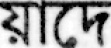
য়াদে
